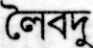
লৈবদু
